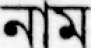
নাম
